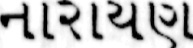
નારાયાણ
